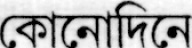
কোনোদিনে
